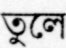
তুলে
